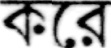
করে
